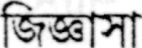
জিজ্ঞাসা
